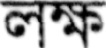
লক্ষ
